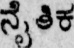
ನೈತಿಕ
